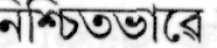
নিশ্চিতভাৱে
